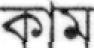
কাম
